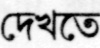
দেখতে
